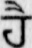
ਹੈ
